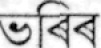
ভৰিৰ
